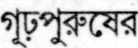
গূঢ়পুরুষের
